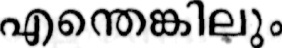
എന്തെങ്കിലും
